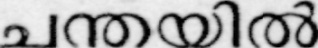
ചന്തയില്‍
